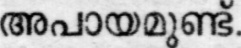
അപായമുണ്ട്.
